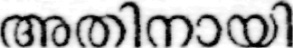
അതിനായി
